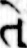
તે
